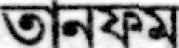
তানফম
